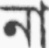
না
